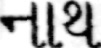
નાથ
